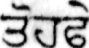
ਤੋਹਫੇ
